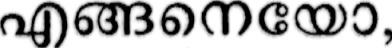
എങ്ങനെയോ,
